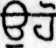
ਉਹੋ
